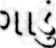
ગાડું
